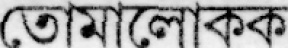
তোমালোকক
